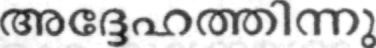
അദ്ദേഹത്തിന്നു
